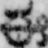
ಈ
